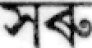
সৰু
